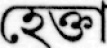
হেক্তা
